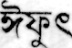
ঈফুৎ
